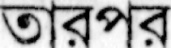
তারপর
